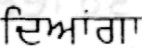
ਦਿਆਂਗਾ
